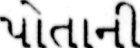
પોતાની
